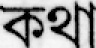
কথা
